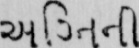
અગ્નિની
